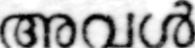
അവള്‍
